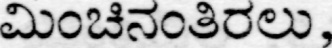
ಮಿಂಚಿನಂತಿರಲು,
